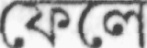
ফেলে
